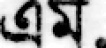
এম.
